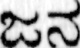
ಜನ
